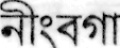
নীংবগা
